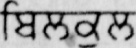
ਬਿਲਕੁਲ
